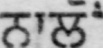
ਨਾਲੋਂ
